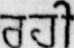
ਰਹੀ
